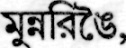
মুন্নরিঙৈ,
